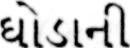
ઘોડાની
